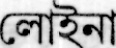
লোইনা
